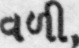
વળી,
